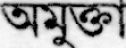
অমক্তা
